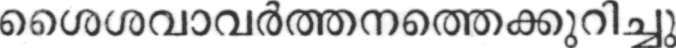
ശൈശവാവര്‍ത്തനത്തെക്കുറിച്ചു
